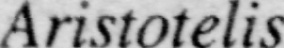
Aristotelis
